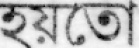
হয়তো
